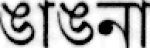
ঙাঙনা
